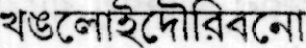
খঙলোইদজৌরিবনো
